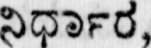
ನಿರ್ಧಾರ,
